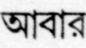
আবার
